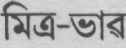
মিত্ৰ-ভাৱ
